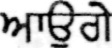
ਆਉਗੇ
